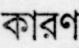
কারণ
